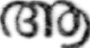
ആ
